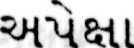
અપેક્ષા
